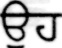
ਉਹ
